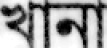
খানা
